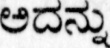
ಅದನ್ನು
